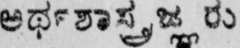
ಅರ್ಥಶಾಸ್ತ್ರಜ್ಞರು
